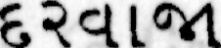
દરવાજા
